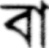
বা
